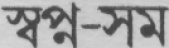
স্বপ্ন-সম
